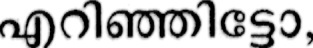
എറിഞ്ഞിട്ടോ,
